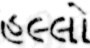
હલ્લો
